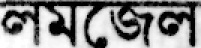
লমজেল
